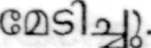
മേടിച്ചു.
